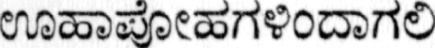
ಊಹಾಪೋಹಗಳಿಂದಾಗಲಿ
